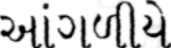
આંગળીયે
